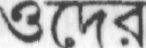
ওদের
